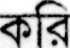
করি
